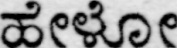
ಹೇಳೋ
